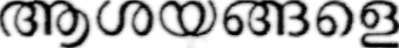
ആശയങ്ങളെ
